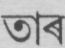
তাৰ
